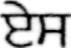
ਏਸ
